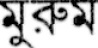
মুরুম
